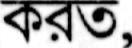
করত,
